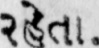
રહેતા.
